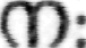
ന:
